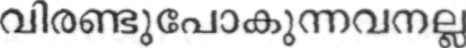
വിരണ്ടുപോകുന്നവനല്ല
